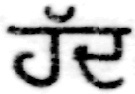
ਹੱਦ
